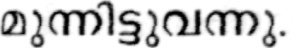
മുന്നിട്ടുവന്നു.
